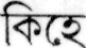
কিহে
